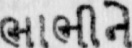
ભાભીને
